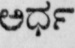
ಅರ್ಧ
